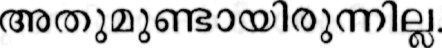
അതുമുണ്ടായിരുന്നില്ല.
